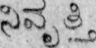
ನಿವೃತ್ತಿ
